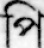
পি
